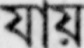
যায়
